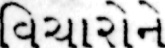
વિચારોને
